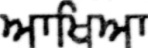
ਆਖਿਆ
